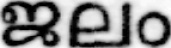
ജലം
